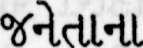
જનેતાના
